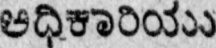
ಅಧಿಕಾರಿಯು
